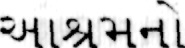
આશ્રમનો
